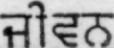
ਜੀਵਨ
